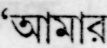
‘আমার
